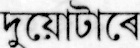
দুয়োটাৰে
